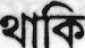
থাকি
